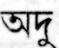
অদু
